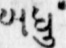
બધું
